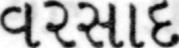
વરસાદ
